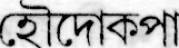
হৌদোকপা
